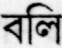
বলি
